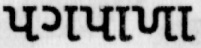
પગપાખા
